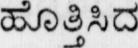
ಹೊತ್ತಿಸಿದ
